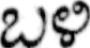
ಬಳಿ
